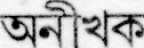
অনীখক
